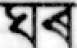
ঘৰ
